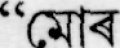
"মোৰ
